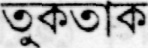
তুকতাক
